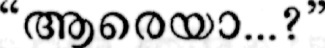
“ആരെയാ...?”
